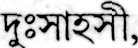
দুঃসাহসী,
